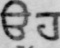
ਉਹ
